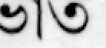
ভাত
